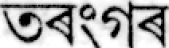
তৰংগৰ
